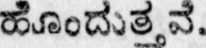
ಹೊಂದುತ್ತವೆ.
